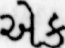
એક
